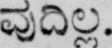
ವುದಿಲ್ಲ.
